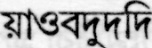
য়াওবদুদদি
